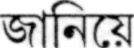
জানিয়ে
